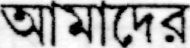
আমাদের
